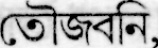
তৌজবনি,
